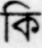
কি
